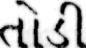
તોડી
